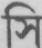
সি
